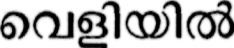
വെളിയില്‍
